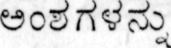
ಅಂಶಗಳನ್ನು
